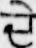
ਦੇ
